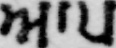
ਆਪ
